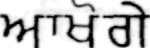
ਆਖੋਗੇ
